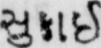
સુકાઈ
